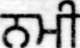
ਨਮੀ
